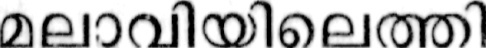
മലാവിയിലെത്തി
